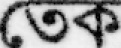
তেক
